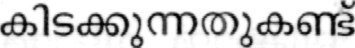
കിടക്കുന്നതുകണ്ട്
